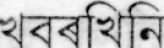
খবৰখিনি
